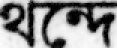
থন্দে
